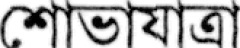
শোভাযাত্রা
